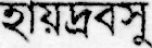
হায়দ্রবসু
